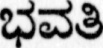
ಭವತಿ
